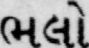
ભલો
